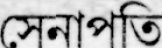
সেনাপতি
